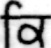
ਕਿ
